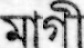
মাগী
